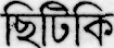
ছিটিকি
